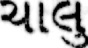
ચાલુ
